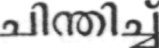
ചിന്തിച്ച്
